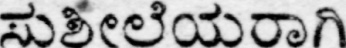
ಸುಶೀಲೆಯರಾಗಿ
